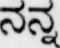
ನನ್ನ
